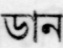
ডান
